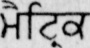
ਮੈਟ੍ਰਿਕ
